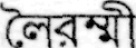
লৈরম্মী
